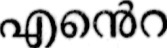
എന്റെ
